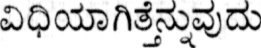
ವಿಧಿಯಾಗಿತ್ತೆನ್ನುವುದು
